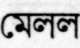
মেলল
